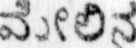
ಮೇಲಿನ
